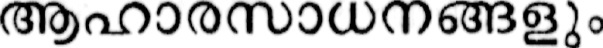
ആഹാരസാധനങ്ങളും
